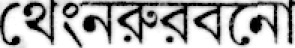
থেংনরুরবনো
